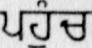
ਪਹੁੰਚ
